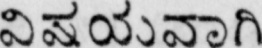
ವಿಷಯವಾಗಿ
